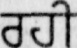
ਰਹੀ
